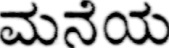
ಮನೆಯ
